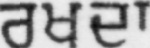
ਰਖਦਾ
